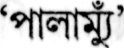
‘পালাম্যুঁ’
